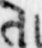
તો
